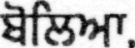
ਬੋਲਿਆ,
